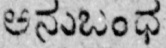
ಅನುಬಂಧ
